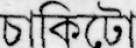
চাকিটো
